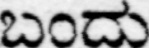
ಬಂದು
